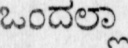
ಒಂದಲ್ಲಾ
